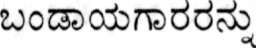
ಬಂಡಾಯಗಾರರನ್ನು
